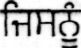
ਜਿਸਨੂੰ
